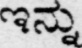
ಇನ್ನು
